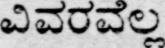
ವಿವರವೆಲ್ಲ
